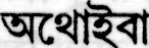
অথোইবা
